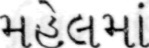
મહેલમાં
